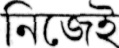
নিজেই
